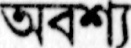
অবশ্য
